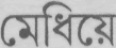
মেধিয়ে
